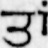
ਤਾਂ
